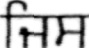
ਜਿਸ
